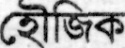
হৌজিক
